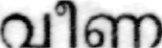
വീണ
